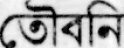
তৌবনি
